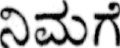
ನಿಮಗೆ
